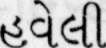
હવેલી
